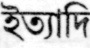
ইত্যাদি
